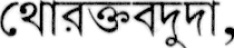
থোরক্তবদুদা,
